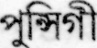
পুন্সিগী
